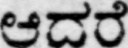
ಆದರೆ
